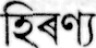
হিৰণ্য
